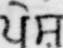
ਪੇਸ਼
